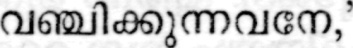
വഞ്ചിക്കുന്നവനേ,’
